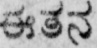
ಈತನ
